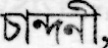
চান্দনী,
